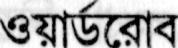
ওয়ার্ডরোব
